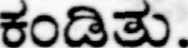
ಕಂಡಿತು.
